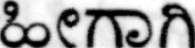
ಹೀಗಾಗಿ
